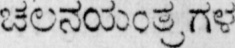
ಚಲನಯಂತ್ರಗಳ
